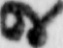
જ
